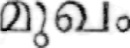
മുഖം
